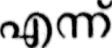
എന്ന്
